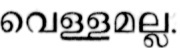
വെള്ളമല്ല.
